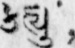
કહ્યું,
